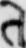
તે
